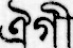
ঐগী
